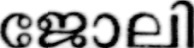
ജോലി
